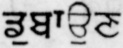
ਡੁਬਾਉਣ
